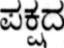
ಪಕ್ಷದ
